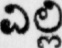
ವಿಲ್ಲಿ
